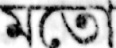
মতো
